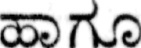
ಹಾಗೂ
